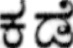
ಕಡೆ
